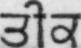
ਤੀਕ
